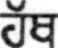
ਹੱਥ
